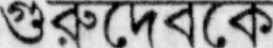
গুরুদেবকে
